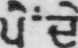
ਪੈਂਦੇ
